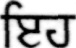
ਇਹ
